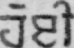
ਹੋਈ
